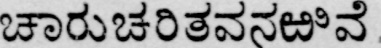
ಚಾರುಚರಿತವನಱಿವೆ
